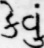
કેવું
